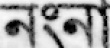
নংনা
